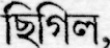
ছিগিল,
